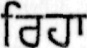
ਰਿਹਾ
